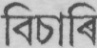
বিচাৰি
